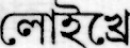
লোইখ্রে
